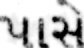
પાસે
